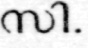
സി.
